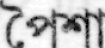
পৈশা
